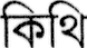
কিথি
